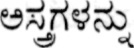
ಅಸ್ತ್ರಗಳನ್ನು
